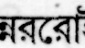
কাদুগী
